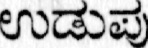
ಉಡುಪು
